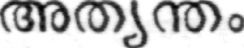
അത്യന്തം
